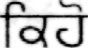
ਕਿਹੋ
